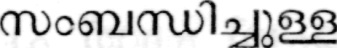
സംബന്ധിച്ചുള്ള
